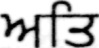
ਅਤਿ
